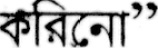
করিনো”
